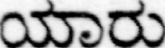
ಯಾರು
